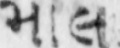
માલ.
